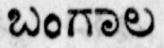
ಬಂಗಾಲ
